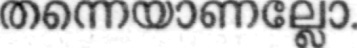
തന്നെയാണല്ലോ.
